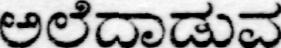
ಅಲೆದಾಡುವ
